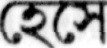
হেসে
